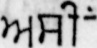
ਅਸੀਂ
